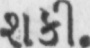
શકી.
